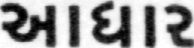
આધાર
